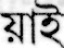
য়াই
